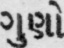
ગુણો
